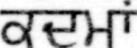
ਕਦਮਾਂ
